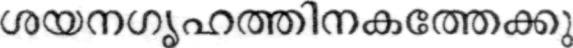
ശയനഗൃഹത്തിനകത്തേക്കു
